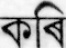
কৰি
